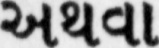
અથવા
